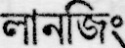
লানজিং
